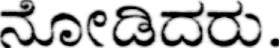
ನೋಡಿದರು.
